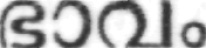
ഭാവം
